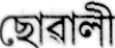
ছোৱালী
